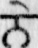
ਨੇ
